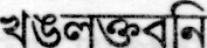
খঙলক্তবনি
